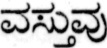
ವಸ್ತುವು
